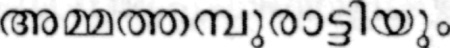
അമ്മത്തമ്പുരാട്ടിയും
